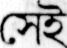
সেই
